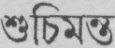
শুচিমন্ত
